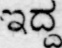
ಇದ್ದ
